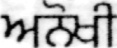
ਅਨੋਖੀ
